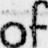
of
